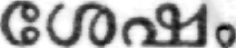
ശേഷം
